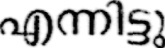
എന്നിട്ടു
